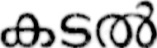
കടല്‍
